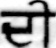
ਦੀ
